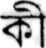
কী
